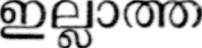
ഇല്ലാത്ത
